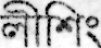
লীশিং
